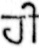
ਹੀ
